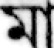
মা
